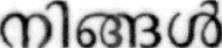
നിങ്ങള്‍
